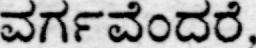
ವರ್ಗವೆಂದರೆ,
